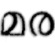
മര
